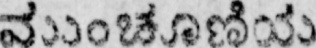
ಮುಂಚೂಣಿಯ
